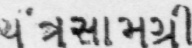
યંત્રસામગ્રી
